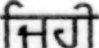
ਜਿਹੀ
